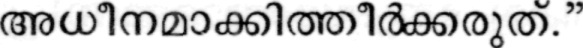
അധീനമാക്കിത്തീര്‍ക്കരുത്."
